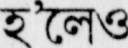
হ'লেও
